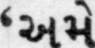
'અમે
